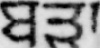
ਬੜਾ
